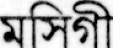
মসিগী
